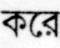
করে
